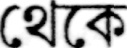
থেকে
